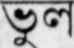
ভুল
